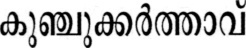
കുഞ്ചുക്കര്‍ത്താവ്
